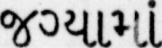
જગ્યામાં
